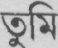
তুমি
